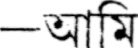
–আমি
